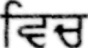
ਵਿਚ
